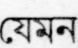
যেমন
